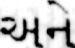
અને
